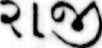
રાજી
